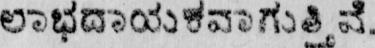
ಲಾಭದಾಯಕವಾಗುತ್ತಿವೆ.
